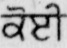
ਕੋਈ
